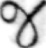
જ
